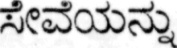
ಸೇವೆಯನ್ನು
